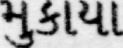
મુકાયા
